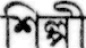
শিল্পী
